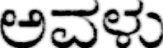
ಅವಳು
